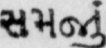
સમજું
